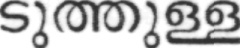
ടുത്തുള്ള
